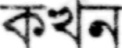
কখন
